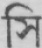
সি
